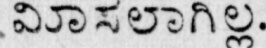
ಮೀಸಲಾಗಿಲ್ಲ.
